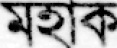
মহাক
